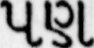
પણ
